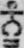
ਨੂੰ
